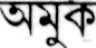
অমুক
